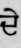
ਦੇ
